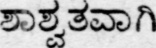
ಶಾಶ್ವತವಾಗಿ
